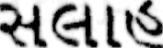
સલાહ
